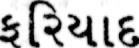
ફરિયાદ
